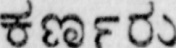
ಕರ್ಣರು
